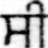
ਸੀ
